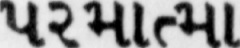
પરમાત્મા
